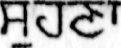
ਸੁਹਣਾ
